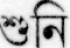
শুনি
